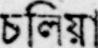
চলিয়া
